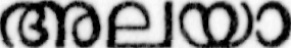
അലയാ
